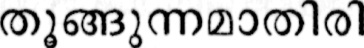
തൂങ്ങുന്നമാതിരി
